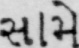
સામે
